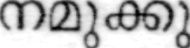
നമുക്കു
